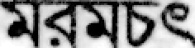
মরমচৎ
